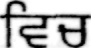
ਵਿਚ
